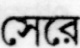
সেরে
